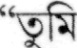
"তুমি
